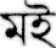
মই
